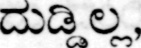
ದುಡ್ಡಿಲ್ಲ,
